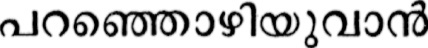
പറഞ്ഞൊഴിയുവാന്‍
